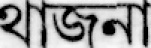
থাজনা
